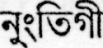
নুংতিগী
